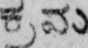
ಕ್ರಮ
